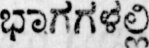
ಭಾಗಗಳಲ್ಲಿ
